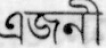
এজনী
